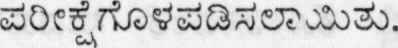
ಪರೀಕ್ಷೆಗೊಳಪಡಿಸಲಾಯಿತು.
